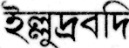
ইল্লুদ্রবদি
